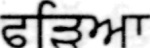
ਫੜਿਆ
